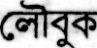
লৌবুক
